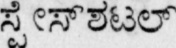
ಸ್ಪೇಸ್‌ಶಟಲ್
